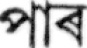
পাৰ
